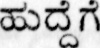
ಹುದ್ದೆಗೆ
